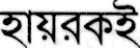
হায়রকই
